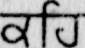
ਕਹਿ
